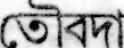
তৌবদা
